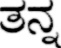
ತನ್ನ
